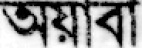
অয়াবা
